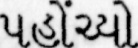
પહોંચ્યો
